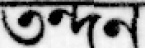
তন্দন
